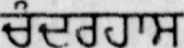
ਚੰਦਰਹਾਸ
